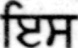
ਇਸ
